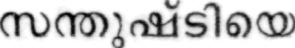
സന്തുഷ്ടിയെ
